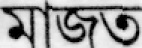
মাজত
